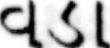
વડા
